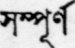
সম্পূর্ণ
